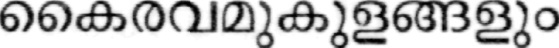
കൈരവമുകുളങ്ങളും
